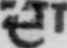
ਦਾ
